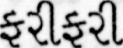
ફરીફરી
